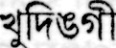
খুদিঙগী
